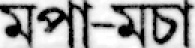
মপা-মচা
